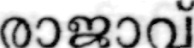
രാജാവ്
